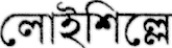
লোইশিল্লে
